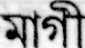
মাগী
